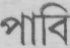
পাবি
